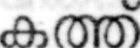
കത്ത്
